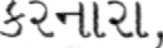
કરનારા,
